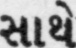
સાથે
